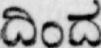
ದಿಂದ
